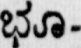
ಭೂ.
